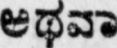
ಅಥವಾ
